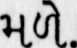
મળે.
